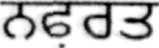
ਨਫ਼ਰਤ
